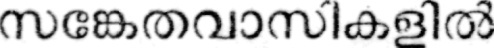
സങ്കേതവാസികളില്‍
